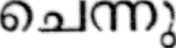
ചെന്നു
